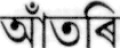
আঁতৰি
